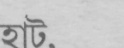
হাট,
